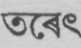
তৰেৎ
